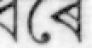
ধৰে
